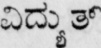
ವಿದ್ಯುತ್
